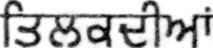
ਤਿਲਕਦੀਆਂ
